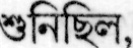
শুনিছিল,
